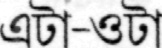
এটা-ওটা
